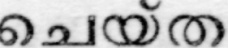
ചെയ്ത
